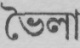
ভৈলা
